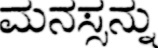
ಮನಸ್ಸನ್ನು
